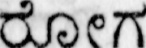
ರೋಗ
